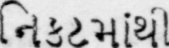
નિકટમાંથી
